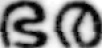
ഭര
